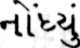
નોંધ્યું
